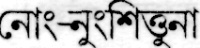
নোং-নুংশিত্তুনা
